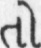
તો
